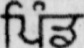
ਪਿੰਡ
